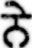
ਨੇ
